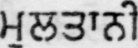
ਮੁਲਤਾਨੀ
